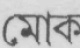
মোক
